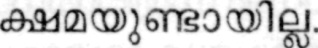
ക്ഷമയുണ്ടായില്ല.
